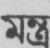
মন্ত্ৰ
